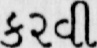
કરવી
